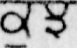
ਕੁਝ
